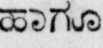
ಹಾಗೂ
